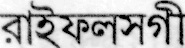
রাইফলসগী
